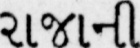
રાજાની
